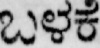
ಬಳಕೆ
